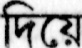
দিয়ে
